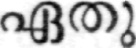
ഏതു
